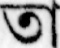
তা
